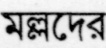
মল্লদের
